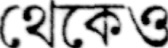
থেকেও
